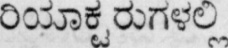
ರಿಯಾಕ್ಟರುಗಳಲ್ಲಿ
